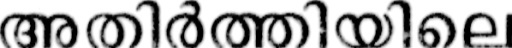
അതിര്‍ത്തിയിലെ
